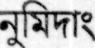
নুমিদাং
